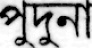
পুদুনা
